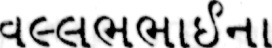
વલ્લભભાઈના
